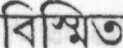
বিস্মিত
